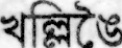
খল্লিঙৈ
